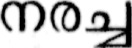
നരച്ച
